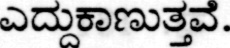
ಎದ್ದುಕಾಣುತ್ತವೆ.
